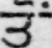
ਤੋਂ
